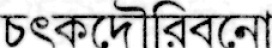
চৎকদৌরিবনো
